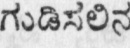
ಗುಡಿಸಲಿನ
